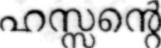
ഹസ്സന്റെ
